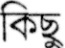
কিছু
